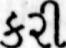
કરી
